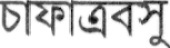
চাফাত্রবসু
